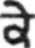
ਕੇ
